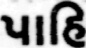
પાહિ
